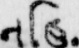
નહિ.
